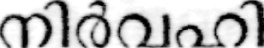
നിര്‍വഹി
